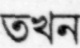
তখন
